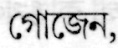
গোজেন,
